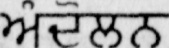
ਅੰਦੋਲਨ
